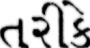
તરીકે
